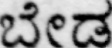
ಬೇಡ
